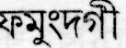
ফমুংদগী
